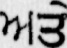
ਅਤੇ
